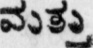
ಮತ್ತು
